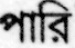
পারি
